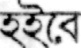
হইবে
